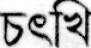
চৎখি
